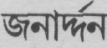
জনাৰ্দ্দন
